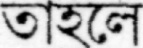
তাহলে
